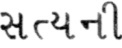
સત્યની
